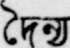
দৈন্য
